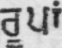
ਰੂਪਾਂ
